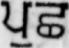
ਪੁਛ
